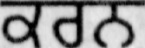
ਕਰਨ
